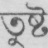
তুষ্ট
